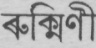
ৰুক্মিণী
